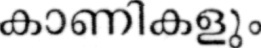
കാണികളും
